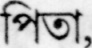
পিতা,
